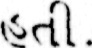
હતી.
